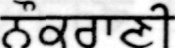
ਨੌਕਰਾਣੀ
